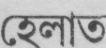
হেলাত
